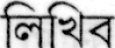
লিখিব
